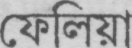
ফেলিয়া
